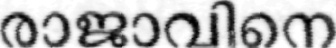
രാജാവിനെ
